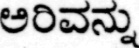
ಅರಿವನ್ನು
